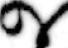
જ
